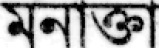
মনাক্তা
